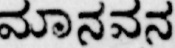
ಮಾನವನ
